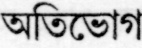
অতিভোগ
